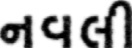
નવલી
